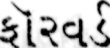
ફૉરવર્ડ
